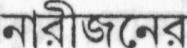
নারীজনের
